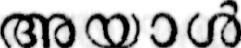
അയാള്‍
